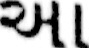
આ
